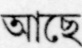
আছে
